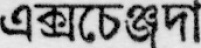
এক্সচেঞ্জদা
